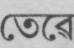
তেৱে
